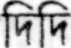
দিদি
